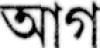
আগ
